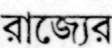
রাজ্যের
